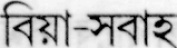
বিয়া-সবাহ
